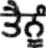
ਤੈਨੂੰ
